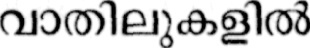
വാതിലുകളില്‍
